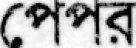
পেপর
